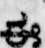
ಈ
